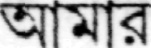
আমার
